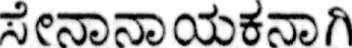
ಸೇನಾನಾಯಕನಾಗಿ
